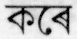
কৰে
